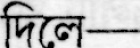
দিলে-
